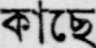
কাছে
